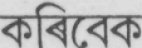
কৰিবেক
